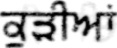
ਕੁੜੀਆਂ
